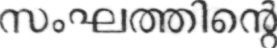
സംഘത്തിന്റെ
